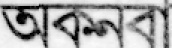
অকনবা
